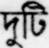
দুটি
